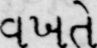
વખતે
